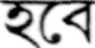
হবে
